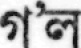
গ'ল
